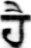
ਹੈ
